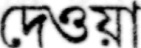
দেওয়া
